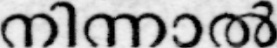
നിന്നാല്‍
